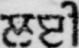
ਲਈ
